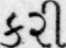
કરી
